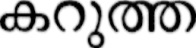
കറുത്ത
